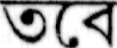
তবে
